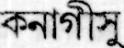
কনাগীসু
